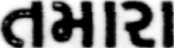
તમારા
